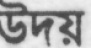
উদয়
